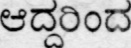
ಆದ್ದರಿ೦ದ
